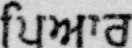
ਪਿਆਰ
